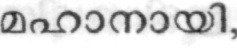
മഹാനായി,
